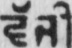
ਵੱਜੀ
